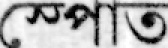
স্পোত
